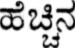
ಹೆಚ್ಚಿನ
